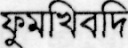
ফুমখিবদি
